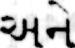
અને
